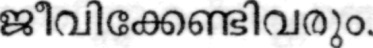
ജീവിക്കേണ്ടിവരും.
